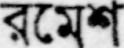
রমেশ
